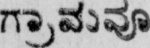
ಗ್ರಾಮವೂ
